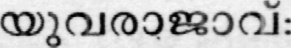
യുവരാജാവ്:
